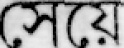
সেয়ে
